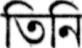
তিনি
